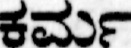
ಕರ್ಮ
